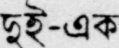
দুই-এক
